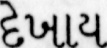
દેખાય
